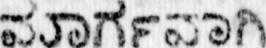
ಮಾರ್ಗವಾಗಿ
